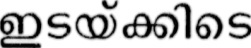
ഇടയ്ക്കിടെ
